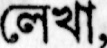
লেখা,
